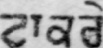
ਟਾਕਰੇ
